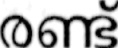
രണ്ട്
